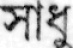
সাধু
